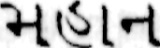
મહાન
